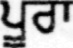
ਪੂਰਾ
